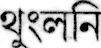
থুংলনি
